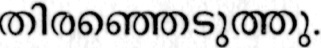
തിരഞ്ഞെടുത്തു.
